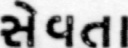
સેવતા
